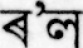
ৰ'ল
